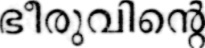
ഭീരുവിന്റെ
